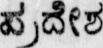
ಪ್ರದೇಶ
